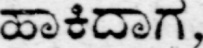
ಹಾಕಿದಾಗ,
